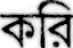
করি
